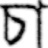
চা
